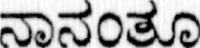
ನಾನಂತೂ
